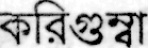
করিগুম্বা
